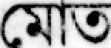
মোত
